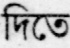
দিতে
